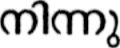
നിന്നു
